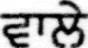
ਵਾਲੇ
